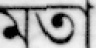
মতা
